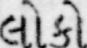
લોકો
